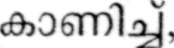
കാണിച്ച്,
